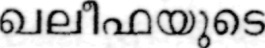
ഖലീഫയുടെ
